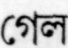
গেল
